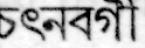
চৎনবগী
